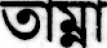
তাম্না
